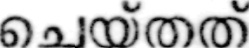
ചെയ്തത്
